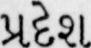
પ્રદેશ
